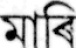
মাৰি
